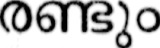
രണ്ടും
